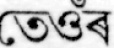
তেওঁৰ
